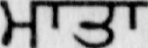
ਮਾਤਾ
